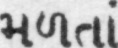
મળતાં
